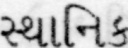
સ્થાનિક
